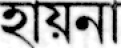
হায়না
